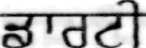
ਡਾਰਟੀ
